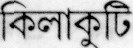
কিলাকুটি
